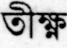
তীক্ষ্ণ
